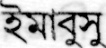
ইমাবুসু
